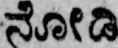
ನೋಡಿ
